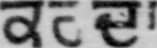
ਕਰਦਾ
